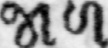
જાળ
